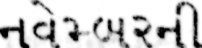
નવેમ્બરની
